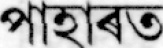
পাহাৰত
